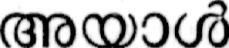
അയാള്‍
